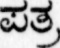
ಪತ್ರ
